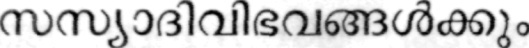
സസ്യാദിവിഭവങ്ങള്‍ക്കും
